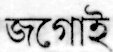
জগোই
